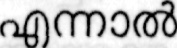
എന്നാല്‍
